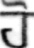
ਹੋ
